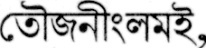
তৌজনীংলমই,
